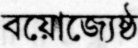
বয়োজ্যেষ্ঠ
